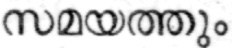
സമയത്തും
